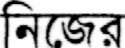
নিজের
